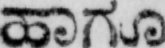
ಹಾಗೂ
